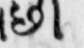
પછી
